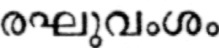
രഘുവംശം
